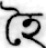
হৈ
